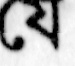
যে
